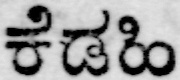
ಕೆಡಹಿ
